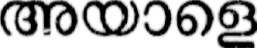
അയാളെ
